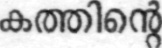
കത്തിന്റെ
